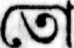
তো
